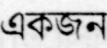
একজন
